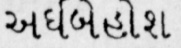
અર્ધબેહોશ
